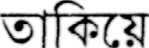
তাকিয়ে
